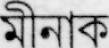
মীনাক
